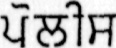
ਪੋਲੀਸ
